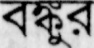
বঙ্কুর
